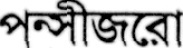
পুন্সীজরো
